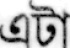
এটা
